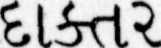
દાક્તર
